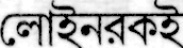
লোইনরকই
